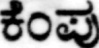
ಕೆಂಪು
